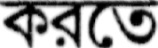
করতে
